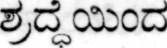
ಶ್ರದ್ಧೆಯಿಂದ
